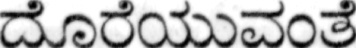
ದೊರೆಯುವಂತೆ
